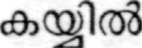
കയ്യില്‍
